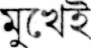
মুখেই
